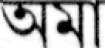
অমা
